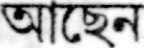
আছেন
